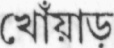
খোঁয়াড়
